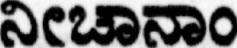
ನೀಚಾನಾ೦
